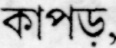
কাপড়,
